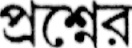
প্রশ্নের
